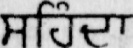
ਸਹਿੰਦਾ
